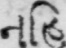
નહિ
